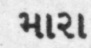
મારા
